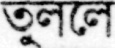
তুললে
